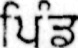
ਪਿੰਡ
